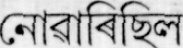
নোৱাৰিছিল
